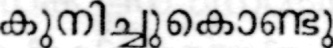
കുനിച്ചുകൊണ്ടു
